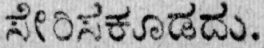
ಸೇರಿಸಕೂಡದು.
